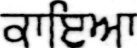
ਕਾਇਆ
